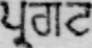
ਪ੍ਰਗਟ
